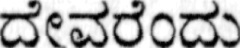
ದೇವರೆಂದು
